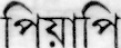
পিয়াপি
